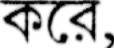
করে,
